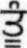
ਤੂੰ
